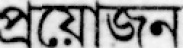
প্রয়োজন
